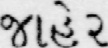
જાહેર
